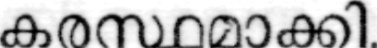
കരസ്ഥമാക്കി.
